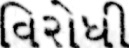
વિરોધી
